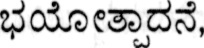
ಭಯೋತ್ಪಾದನೆ,
